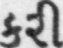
કરી
